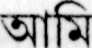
আমি
